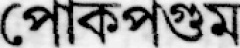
পোকপগুম
